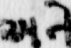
અને
